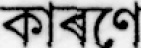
কাৰণে
